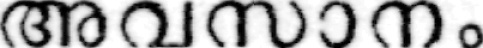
അവസാനം
